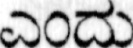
ಎಂದು
